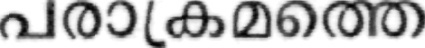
പരാക്രമത്തെ
